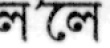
ল'লে
